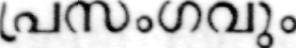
പ്രസംഗവും
